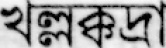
খল্লক্কদ্রা
